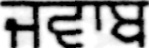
ਜਵਾਬ
